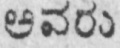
ಅವರು
